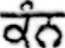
ਕੰਨ
